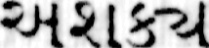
અશક્ય
